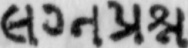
લગ્નપ્રશ્ન
